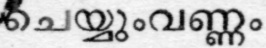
ചെയ്യുംവണ്ണം
